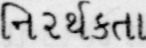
નિરર્થકતા
